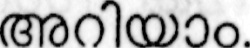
അറിയാം.
